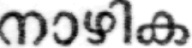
നാഴിക
